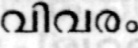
വിവരം
